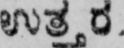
ಉತ್ತರ.
